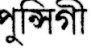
পুন্সিগা
